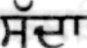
ਸੱਦਾ
